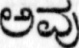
ಅವು
